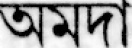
অমদা
